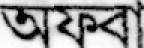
অফবা
